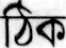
ঠিক
